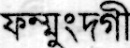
ফম্মুংদগী
